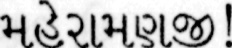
મહેરામણજી!
